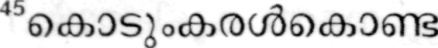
45കൊടുംകരള്‍കൊണ്ട
